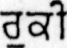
ਰੁਕੀ
